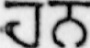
ਹਨ
